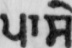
ਪਾਸੇ
